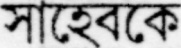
সাহেবকে
